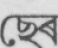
ছেৰ
